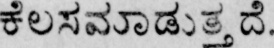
ಕೆಲಸಮಾಡುತ್ತದೆ.
